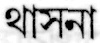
থাসনা
